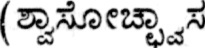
(ಶ್ವಾಸೋಚ್ಛ್ವಾಸ
